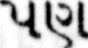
પણ
